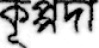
কূপ্পদা
